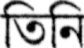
তিনি
